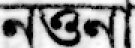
নত্তনা
